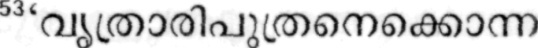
53'വൃത്രാരിപുത്രനെക്കൊന്ന
